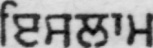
ਇਸਲਾਮ
